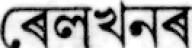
ৰেলখনৰ
